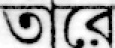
তারে
